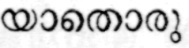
യാതൊരു
